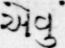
એવું
